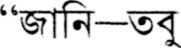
“জানি–তবু
